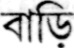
বাড়ি
